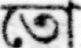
তো
